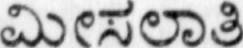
ಮೀಸಲಾತಿ
